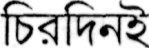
চিরদিনই
